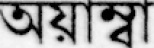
অয়াম্বা
